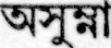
অসুম্না
